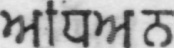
ਅਧਿਅਨ
